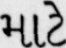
માટે
